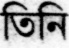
তিনি
